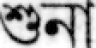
শুনা
